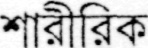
শারীরিক
